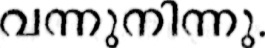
വന്നുനിന്നു.
